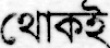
থোকই
